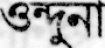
ওন্দুনা
